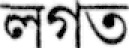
লগত
